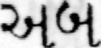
અબ
